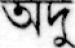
অদু
